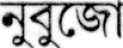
নুবুজো
